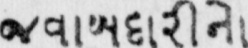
જવાબદારીનો
